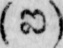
(ಐ)
